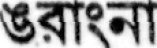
ঙরাংনা
